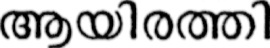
ആയിരത്തി
